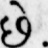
છે.
